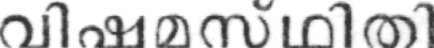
വിഷമസ്ഥിതി
